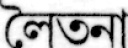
লৈতনা
